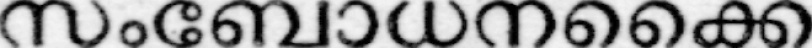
സംബോധനക്കൈ
